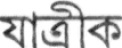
যাত্রীক
